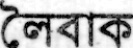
লৈবাক
